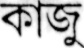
কাজু
